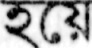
হয়ে
